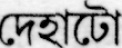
দেহাটো
